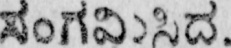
ಸಂಗಮಿಸಿದ.
